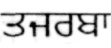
ਤਜਰਬਾ
